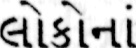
લોકોનાં
